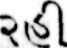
રહી
